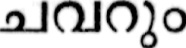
ചവറും
